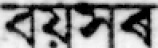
বয়সৰ
